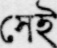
সেই
